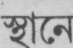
স্থানে
